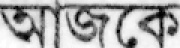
আজকে
